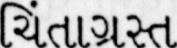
ચિંતાગ્રસ્ત
